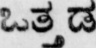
ಒತ್ತಡ
